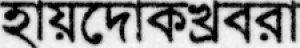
হায়দোকখ্রবরা
